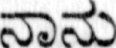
ನಾನು
